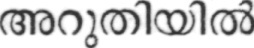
അറുതിയില്‍
